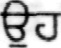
ਉਹ
